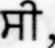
ਸੀ,
